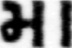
મા
